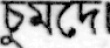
চুমদে।
